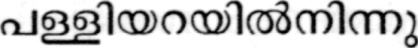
പള്ളിയറയില്‍നിന്നു
